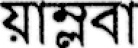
য়াম্লবা
